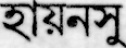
হায়নসু
